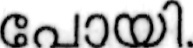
പോയി.
